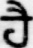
ਹੈ
